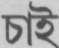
চাই
